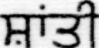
ਸ਼ਾਂਤੀ
